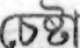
চেষ্টা
